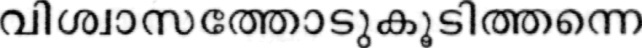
വിശ്വാസത്തോടുകൂടിത്തന്നെ
